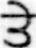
ਤੇ
